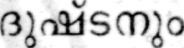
ദുഷ്ടനും
